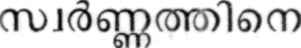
സ്വര്‍ണ്ണത്തിനെ
